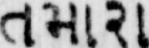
તમારા
